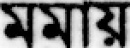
মমায়
